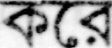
করে
